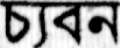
চ্যবন
